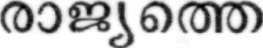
രാജ്യത്തെ
